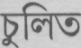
চুলিত
